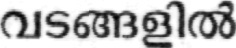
വടങ്ങളില്‍
